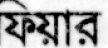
ফিয়ার
